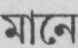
মানে
